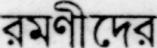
রমণীদের
